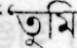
"তুমি
